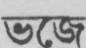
ভজে
